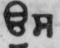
ਉਸ
